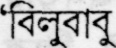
‘বিলুবাবু
